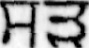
ਸੜ
